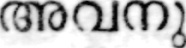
അവനു
